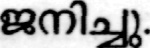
ജനിച്ചു
